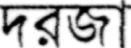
দরজা
